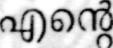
എന്റെ
